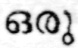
ഒരു
